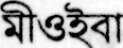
মীওইবা
